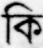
কি
